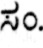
ಸಂ.
